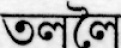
তললৈ
